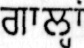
ਗਾਲ੍ਹਾਂ
